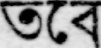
তবে
